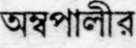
অম্বপালীর
